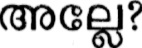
അല്ലേ?
